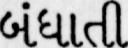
બંધાતી
